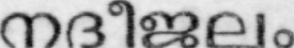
നദീജലം
